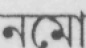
নমো
